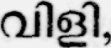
വിളി,
